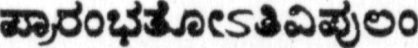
ಪ್ರಾರಂಭತೋsತಿವಿಪುಲಂ
